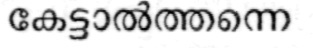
കേട്ടാല്‍ത്തന്നെ
